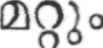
മറ്റും
